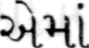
એમાં
